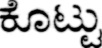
ಕೊಟ್ಟು
